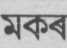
মকৰ
